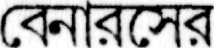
বেনারসের
